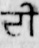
ਦੀ
